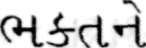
ભક્તને
